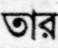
তার
